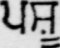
ਪਸ਼ੂ
